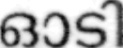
ഓടി
